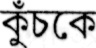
কুঁচকে
